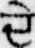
ਦੇ
